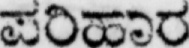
ಪರಿಹಾರ
